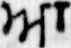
ਆ
